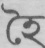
হৈ
